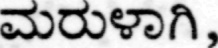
ಮರುಳಾಗಿ,
